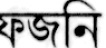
ফজনি
